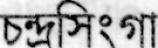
চন্দ্রসিংগা
